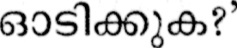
ഓടിക്കുക?’
